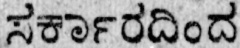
ಸರ್ಕಾರದಿಂದ
